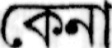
কেনা
